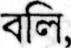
বলি,
